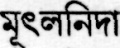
মূৎলনিদা
